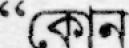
"কোন
